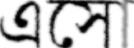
এসো
